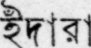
ইঁদারা
